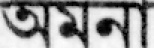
অমনা
